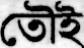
তৌই
